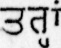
ਤਰ੍ਹਾਂ
